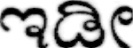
ಇಡೀ
